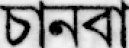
চানবা
